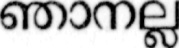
ഞാനല്ല
